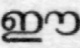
ഈ
